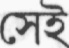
সেই
